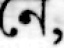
নে,
